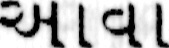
આવા
